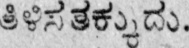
ತಿಳಿಸತಕ್ಕುದು.
